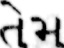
તેમ
